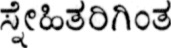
ಸ್ನೇಹಿತರಿಗಿಂತ
